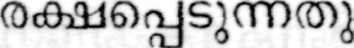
രക്ഷപ്പെടുന്നതു
